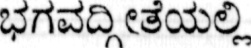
ಭಗವದ್ಗೀತೆಯಲ್ಲಿ
